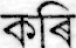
কৰি
